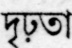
দৃঢ়তা
